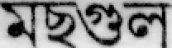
মছগুল
